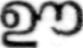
ഊ
